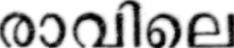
രാവിലെ
